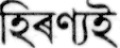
হিৰণ্যই
